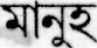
মানুহ
